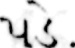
પડે.
